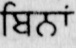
ਬਿਨਾਂ
